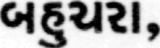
બહુચરા,
